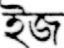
ইজ
